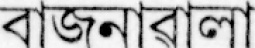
বাজনাৱালা
